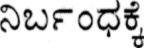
ನಿರ್ಬಂಧಕ್ಕೆ
